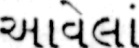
આવેલાં
